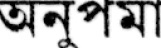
অনুপমা
